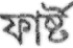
ফাৰ্ষ্ট
